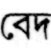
বেদ
